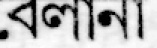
বেলানা
